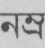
নম্ৰ
